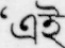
'এই
